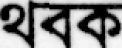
থবক
